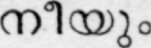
നീയും
